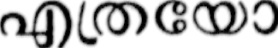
എത്രയോ
